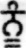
ਨੂੰ
